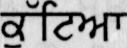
ਕੁੱਟਿਆ
